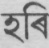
হৰি
